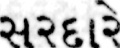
સરદારે
